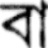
বা
